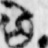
છે.
